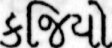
કજિયો
